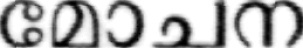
മോചന
